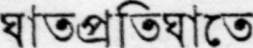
ঘাতপ্রতিঘাতে
